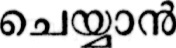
ചെയ്യാന്‍
